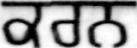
ਕਰਨ
